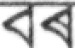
বৰ
